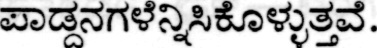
ಪಾಡ್ಡನಗಳೆನ್ನಿಸಿಕೊಳ್ಳುತ್ತವೆ.
